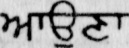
ਆਉਣਾ
